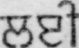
ਲਈ
